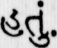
હતું.
